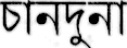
চানদুনা
